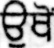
ਉਥੋਂ
